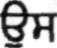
ਉਸ
